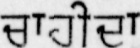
ਚਾਹੀਦਾ
